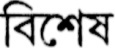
বিশেষ
